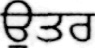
ਉਤਰ
